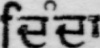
ਦਿੰਦਾ
